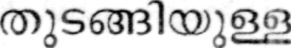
തുടങ്ങിയുള്ള
